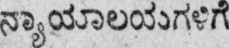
ನ್ಯಾಯಾಲಯಗಳಿಗೆ
